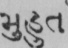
મુહુતં
